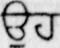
ਉਹ
